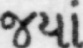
જ્યાં
